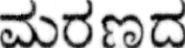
ಮರಣದ
